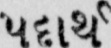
પદાર્થ
